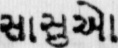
સાસુઓ
